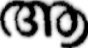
ആ
